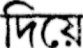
দিয়ে
